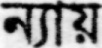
ন্যায়
